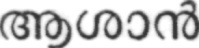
ആശാന്‍
